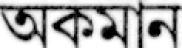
অকমান
